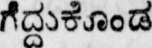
ಗೆದ್ದುಕೊಂಡ
